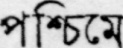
পশ্চিমে
